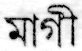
মাগী
